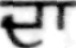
ਦਾ
